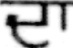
ਦਾ
